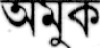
অমুক
